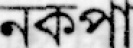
নকপা
